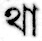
থা
